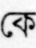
কে
